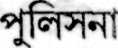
পুলিসনা
